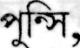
পুন্সি,
